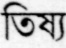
তিষ্য
